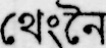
থেংনৈ
